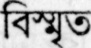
বিস্মৃত
